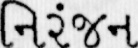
નિરંજન
